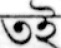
তই
